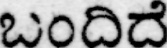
ಬಂದಿದೆ
